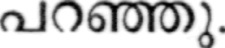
പറഞ്ഞു.
